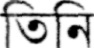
তিনি
